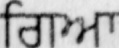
ਗਿਆ
